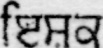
ਇਸ਼ਕ
